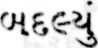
બદલ્યું
